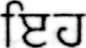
ਇਹ
